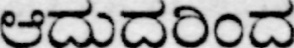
ಆದುದರಿಂದ
